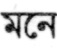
মনে
